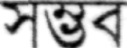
সম্ভব
